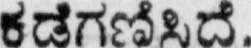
ಕಡೆಗಣಿಸಿದೆ.
